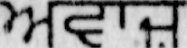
ਅਵਾਜ਼
